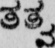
ತತ್ವ
